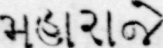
મહારાજે
